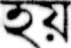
হয়
